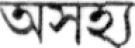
অসহ্য
